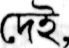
দেই,
